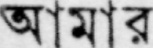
আমার
